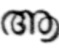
ആ
